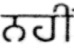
ਨਹੀਂ
